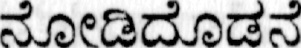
ನೋಡಿದೊಡನೆ
